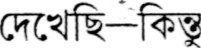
দেখেছি–কিন্তু
